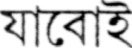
যাবোই
